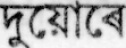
দুয়োৰে
